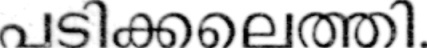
പടിക്കലെത്തി.
